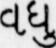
વધુ
